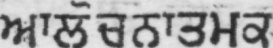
ਆਲੋਚਨਾਤਮਕ
